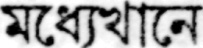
মধ্যেখানে
